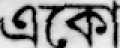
একো
